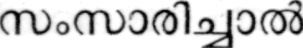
സംസാരിച്ചാല്‍
